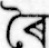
ৰৈ
